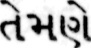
તેમણે
